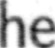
he
